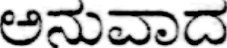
ಅನುವಾದ
